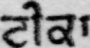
ਟੀਕਾ
